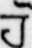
ਹੋ
